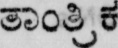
ತಾಂತ್ರಿಕ
